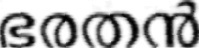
ഭരതന്‍
